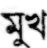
মুখ
